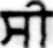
ਸੀ
